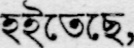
হইতেছে,
